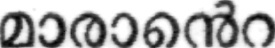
മാരാന്റെ
